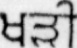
ਖੜੀ
